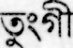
তুংগী
